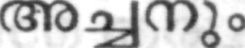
അച്ചനും
